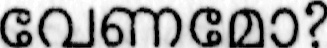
വേണമോ?
